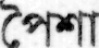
পৈশা
